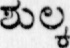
ಶುಲ್ಕ
